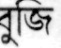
বুজি
